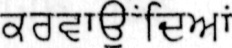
ਕਰਵਾਉਂਦਿਆਂ
